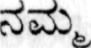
ನಮ್ಮ
